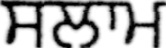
ਸਲਾਮ
